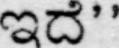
ಇದೆ"
